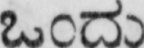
ಒಂದು
